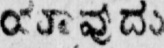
ಯಾವುದು
